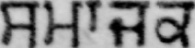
ਸਮਾਜਕ
